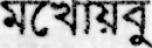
মখোয়বু
